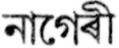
নাগেৰী
